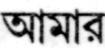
আমার
